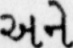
અને
